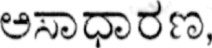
ಅಸಾಧಾರಣ,
